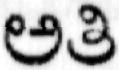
ಅತಿ
